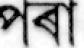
পৰা
